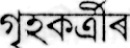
গৃহকৰ্ত্রীৰ
